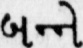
બન્ને
